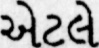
એટલે
